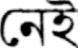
নেই
